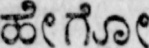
ಹೇಗೋ
